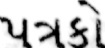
પત્રકો
